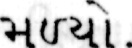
મળ્યો.
